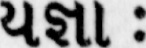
યજ્ઞાઃ
